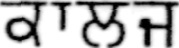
ਕਾਲਜ
